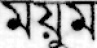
ময়ুম
